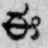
ಈ
